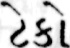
ટેકો
